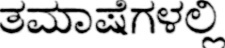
ತಮಾಷೆಗಳಲ್ಲಿ
